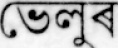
ভেলুৰ
